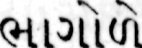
ભાગોળે
